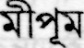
মীপূম
